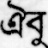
ঐবু
